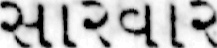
સારવાર
